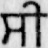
ਸੀ
